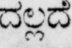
ದಲ್ಲದೆ
